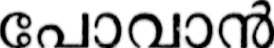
പോവാന്‍
